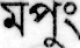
মপুং
